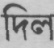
দিল
